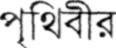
পৃথিবীর
